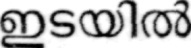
ഇടയില്‍
